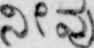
ನೀವು
